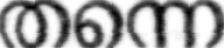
തന്നെ
